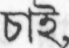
চাই,
